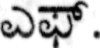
ಎಫ್.
